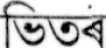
ভিতৰ
